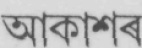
আকাশৰ
